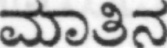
ಮಾತಿನ
